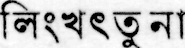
লিংখৎতুনা
